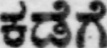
ಕಡೆಗೆ
